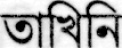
তাখিনি
